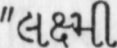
"લક્ષ્મી
